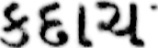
કદાચ
